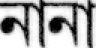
নানা
